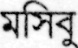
মসিবু
